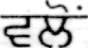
ਵਲੋਂ
